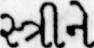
સ્ત્રીને
